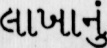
લાખાનું
